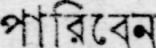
পারিবেন
